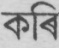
কৰি
